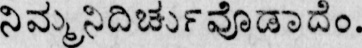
ನಿಮ್ಮನಿದಿರ್ಚುವೊಡಾದೆಂ.
